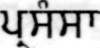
ਪ੍ਰਸੰਸਾ
